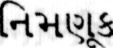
નિમણૂક
